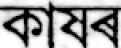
কাষৰ
